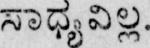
ಸಾಧ್ಯವಿಲ್ಲ.
